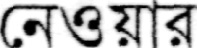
নেওয়ার
